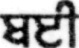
ਬਈ
